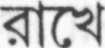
রাখে
